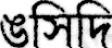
ঙসিদি
